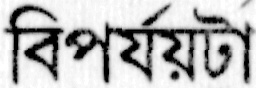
বিপর্যয়টা
